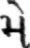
મે
